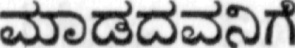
ಮಾಡದವನಿಗೆ
